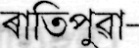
ৰাতিপুৱা-
